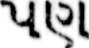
પણ
